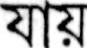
যায়
